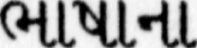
ભાષાના
